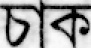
চাক
